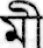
মী
